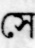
সে
